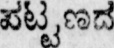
ಪಟ್ಟಣದ
